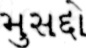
મુસદ્દો
